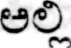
ಅಲ್ಲಿ
